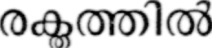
രക്തത്തില്‍
